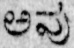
ಅವು
